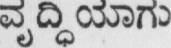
ವೃದ್ಧಿಯಾಗು
